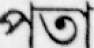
পতা
